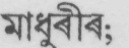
মাধুৰীৰ;
